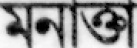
মনাক্তা
